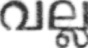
വല്ല
